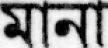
মানা
